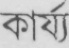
কাৰ্য্য
